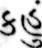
કહું
